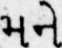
મને
